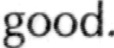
good.
